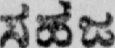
ಸಹಜ
